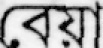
বেয়া
